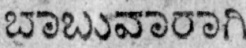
ಬಾಬುವಾರಾಗಿ
